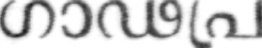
ഗാഢപ്ര
